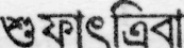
শুফাৎত্রিবা
